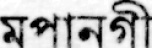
মপানগী
